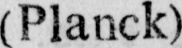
(Planck)
